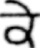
ਕੇ
